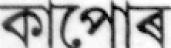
কাপোৰ
